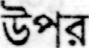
উপর
